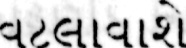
વટલાવાશે
